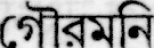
গৌরমনি
